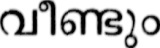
വീണ്ടും
